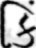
કિં
